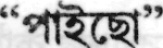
"পাইছো"
